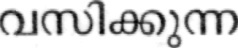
വസിക്കുന്ന
